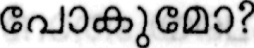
പോകുമോ?
